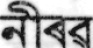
নীৰৱ
